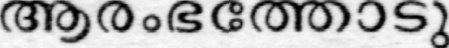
ആരംഭത്തോടു
